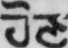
ਹੋਣ
